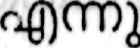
എന്നു
